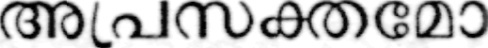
അപ്രസക്തമോ
